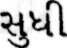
સુધી
